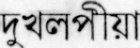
দুখলপীয়া
